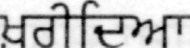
ਖ਼ਰੀਦਿਆ
